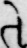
તે
